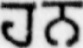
ਹਨ
